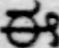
ಈ
